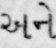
અને
